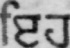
ਇਹ
